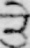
ਤੇ
